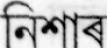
নিশাৰ
